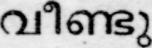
വീണ്ടു
